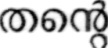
തന്റെ
